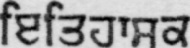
ਇਤਿਹਾਸਕ
